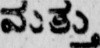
ಮತ್ತು
